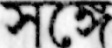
সঙ্গে
